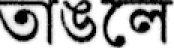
তাঙলে
